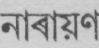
নাৰায়ণ
